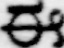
ಈ
